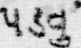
પડવું
